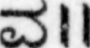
ವ||
